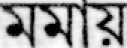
মমায়
